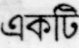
একটি
